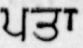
ਪਤਾ
